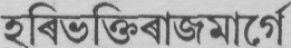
হৰিভক্তিৰাজমাৰ্গে
